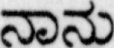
ನಾನು
